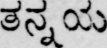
ತನ್ನಯ
